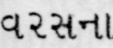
વરસના
